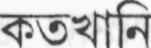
কতখানি
